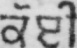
ਕੋਈ
